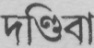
দণ্ডিবা
